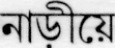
নাড়ীয়ে
